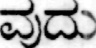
ವುದು
